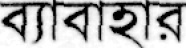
ব্যাবাহার
